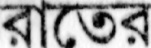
রাতের
